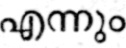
എന്നും
